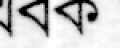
থবক
